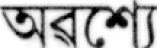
অৱশ্যে
